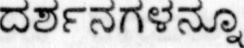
ದರ್ಶನಗಳನ್ನೂ
